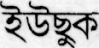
ইউছুক
